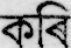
কৰি
